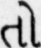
તો
